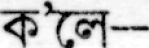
ক'লে-
